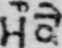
ਮੌਕੇ
